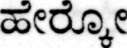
ಹೇರ್ಕೋ
